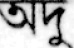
অদু
